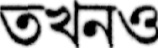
তখনও
